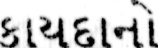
કાયદાનો
